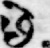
છે.
